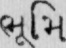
ભૂમિ
